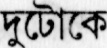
দুটোকে
